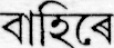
বাহিৰে
